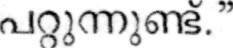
പറ്റുന്നുണ്ട്."
